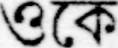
ওকে
